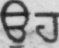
ਉਹ
